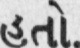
હતો.
